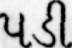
પડી
